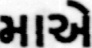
માએ
